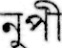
নুপী
